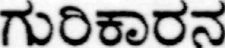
ಗುರಿಕಾರನ
